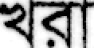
খরা
